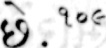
છે.૧૦૯
